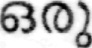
ഒരു
